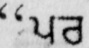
''ਪਰ
